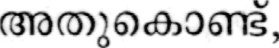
അതുകൊണ്ട്,
